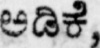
ಅಡಿಕೆ,
